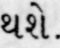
થશે.
